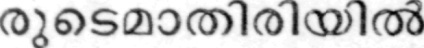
രുടെമാതിരിയില്‍
